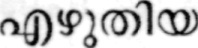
എഴുതിയ
